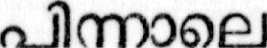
പിന്നാലെ
